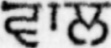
ਵਾਲ
